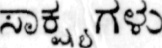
ಸಾಕ್ಷ್ಯಗಳು
